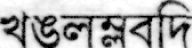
খঙলম্লবদি
